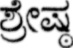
ಶ್ರೇಷ್ಠ
